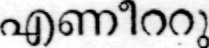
എണീററു
